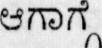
ಆಗಾಗ್ಗೆ
